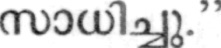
സാധിച്ചു."
